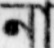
না
